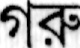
গরু
